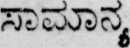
ಸಾಮಾನ್ಯ
